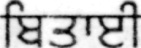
ਬਿਤਾਈ
